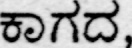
ಕಾಗದ,
